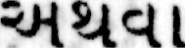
અથવા
